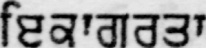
ਇਕਾਗਰਤਾ
